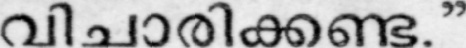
വിചാരിക്കണ്ട.
